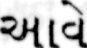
આવે
